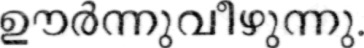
ഊര്‍ന്നുവീഴുന്നു.
